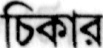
চিকার
